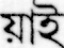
য়াই
